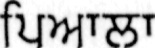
ਪਿਆਲਾ
